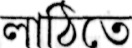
লাঠিতে
